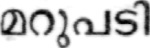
മറുപടി
